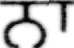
ਨਾ
